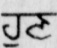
ਹੁਣ
